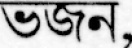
ভজন,
